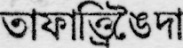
তাফাত্ত্রিঙৈদা
